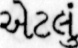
એટલું
